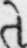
તે
